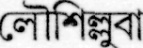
লৌশিল্লুবা
